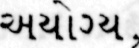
અયોગ્ય,
